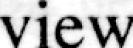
view
